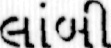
લાંબી
